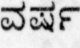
ವರ್ಷ
